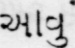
આવું
